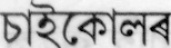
চাইকোলৰ
